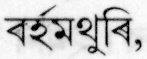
বর্হমথুৰি,
